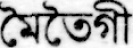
মৈতৈগী
